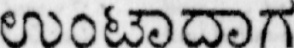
ಉಂಟಾದಾಗ
